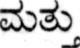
ಮತ್ತು
